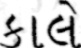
કાલે
